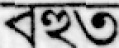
বহুত
